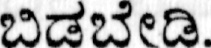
ಬಿಡಬೇಡಿ.
